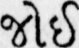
જોઈ
